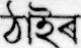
ঠাইৰ
